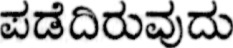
ಪಡೆದಿರುವುದು
